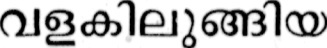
വളകിലുങ്ങിയ
